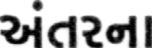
અંતરના
